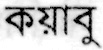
কয়াবু
